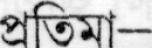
প্রতিমা-
